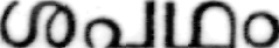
ശപഥം
